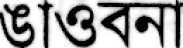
ঙাওবনা
